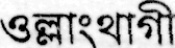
ওল্লাংথাগী
